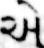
એ
